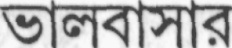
ভালবাসার
